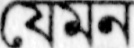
যেমন
